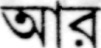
আর
